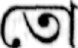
তো
